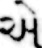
એ
